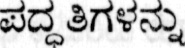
ಪದ್ಧತಿಗಳನ್ನು
